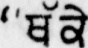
''ਥੱਕੇ
